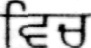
ਵਿਚ
